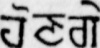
ਹੋਣਗੇ
